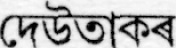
দেউতাকৰ
